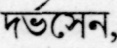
দর্ভসেন,
